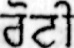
ਰੋਟੀ
